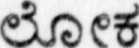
ಲೋಕ
